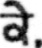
ਕੇ,
